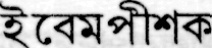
ইবেমপীশক
